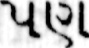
પણ
